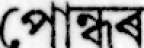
পোন্ধৰ
